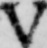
V
